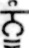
ਨੂੰ
